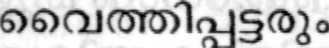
വൈത്തിപ്പട്ടരും
